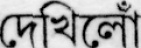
দেখিলোঁ
